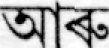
আৰু
